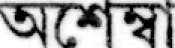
অশেম্বা
